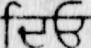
ਦਿਓ
